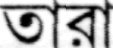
তারা
